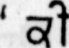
'ਕੀ
